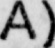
A)
